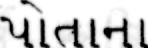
પોતાના
